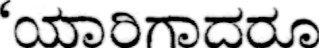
'ಯಾರಿಗಾದರೂ
